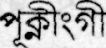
পূক্নীংগী
